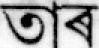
তাৰ
